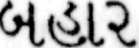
બહાર
